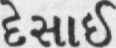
દેસાઈ
